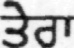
ਤੇਰਾ
